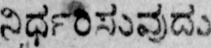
ನಿರ್ಧರಿಸುವುದು
